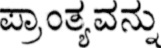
ಪ್ರಾಂತ್ಯವನ್ನು
